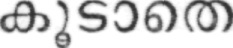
കൂടാതെ
